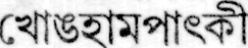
খোঙহামপাৎকী
